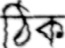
ঠিক
